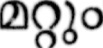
മറ്റും
